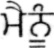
ਮੈਨੂੰ
